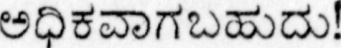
ಅಧಿಕವಾಗಬಹುದು!
